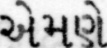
એમણે
